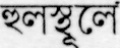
হুলস্হূলে
